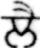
ਲੈ
